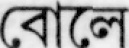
বোলে
